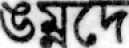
ঙম্নদে
